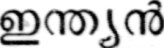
ഇന്ത്യന്‍
